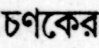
চণকের
